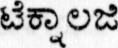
ಟೆಕ್ನಾಲಜಿ
